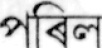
পৰিল
